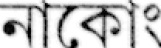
নাকোং
